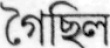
গৈছিল
